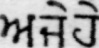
ਅਜੇਹੇ
